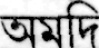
অমদি
